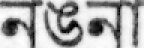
নঙনা
